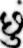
છું
